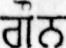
ਗੌਨ
